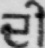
ਦੀ
